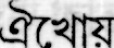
ঐখোয়
